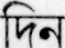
দিন
